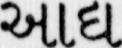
આદ્ય
